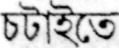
চটাইতে
